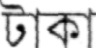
টাকা
